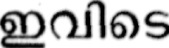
ഇവിടെ
